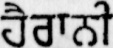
ਹੈਰਾਨੀ
